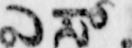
ಎಸ್.
